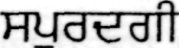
ਸੁਪਰਦਗੀ
